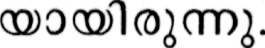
യായിരുന്നു.
